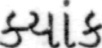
ક્યાંક
